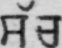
ਸੱਚ
